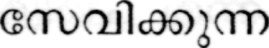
സേവിക്കുന്ന
